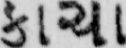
કાચા
